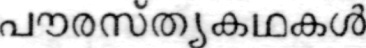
പൌരസ്ത്യകഥകള്‍
